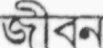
জীবন
